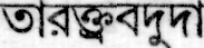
তারক্ত্রবদুদা
